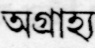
অগ্রাহ্য
